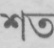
শত
